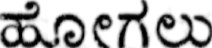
ಹೋಗಲು
